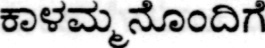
ಕಾಳಮ್ಮನೊಂದಿಗೆ
